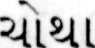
ચોથા
